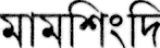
মামশিংদি
